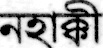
নহাক্কী
